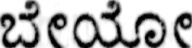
ಬೇಯೋ
